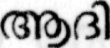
ആദി
